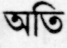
অতি
